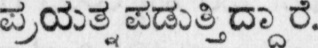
ಪ್ರಯತ್ನಪಡುತ್ತಿದ್ದಾರೆ.
